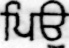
ਪਿਉ
